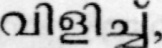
വിളിച്ച്,
